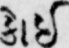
કોઈ
